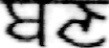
ਬਣ
